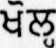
ਖੋਲ੍ਹ
